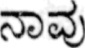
ನಾವು
